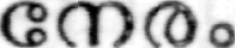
നേരം
